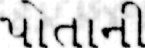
પોતાની
